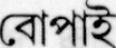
বোপাই
